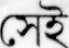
সেই
